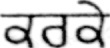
ਕਰਕੇ
